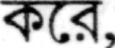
করে,
